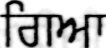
ਗਿਆ
